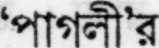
‘পাগলী’র
